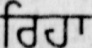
ਰਿਹਾ
